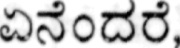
ಏನೆಂದರೆ,
